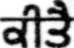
ਕੀਤੈ
